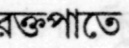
রক্তপাতে
